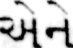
એને
